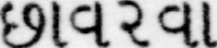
છાવરવા
